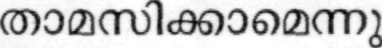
താമസിക്കാമെന്നു
